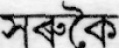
সৰুকৈ
